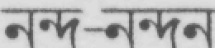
নন্দ-নন্দন
